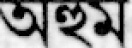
অহুম
